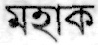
মহাক
